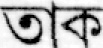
তাক
